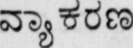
ವ್ಯಾಕರಣ
